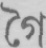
গৈ
